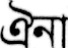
ঐনা
